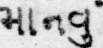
માનવું
